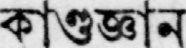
কাণ্ডজ্ঞান
